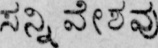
ಸನ್ನಿವೇಶವು
